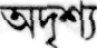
অদৃশ্য
